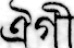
ঐগী
